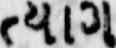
ત્યાગ
